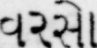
વરસો
